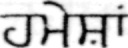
ਹਮੇਸ਼ਾਂ
